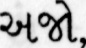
અજો,
